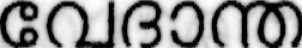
വേദാന്ത
